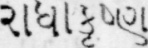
રાધાકૃષ્ણ
